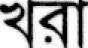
খরা
